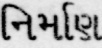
નિર્માણ
